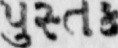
પુસ્તક
